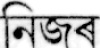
নিজৰ
